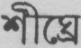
শীঘ্ৰে
